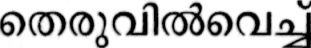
തെരുവില്‍വെച്ച്
